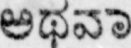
ಅಥವಾ
